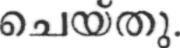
ചെയ്തു.
